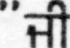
''ਜੀ
